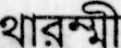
থারম্মী
